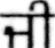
ਜੀ
